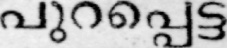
പുറപ്പെട്ട
